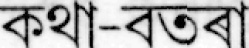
কথা-বতৰা
